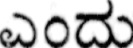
ಎಂದು
